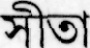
সীতা
